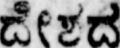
ದೇಶದ
